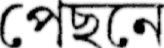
পেছনে
